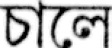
চালে
